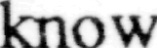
know
